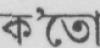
ক'তো
